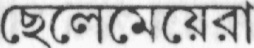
ছেলেমেয়েরা
